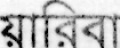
য়ারিবা
